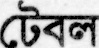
টেবল
